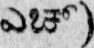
ಎಚ್)
